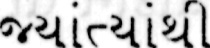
જ્યાંત્યાંથી
